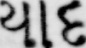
યાદ
